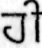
ਹੀ
